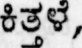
ಕಿತ್ತಳೆ,
